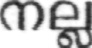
നല്ല
